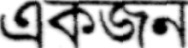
একজন
